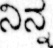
ನಿನ್ನ
